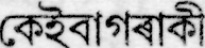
কেইবাগৰাকী
